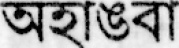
অহাঙবা
